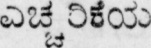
ಎಚ್ಚರಿಕೆಯ
